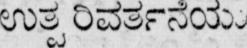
ಉತ್ಪರಿವರ್ತನೆಯು
